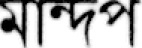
মান্দপ
